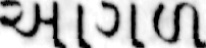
આગળ
